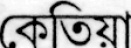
কেতিয়া
